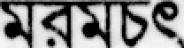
মরমচৎ
